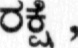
ರಕ್ಷೆ,
